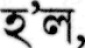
হ'ল,
